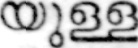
യുള്ള
